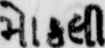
મોકલી
